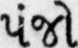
પંજો
